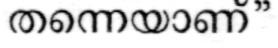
തന്നെയാണ്”
